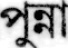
পুন্না
